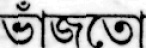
ভাঁজতো
